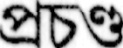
প্রচণ্ড
